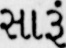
સારૂં
